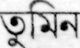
তুমিন
